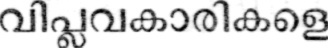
വിപ്ലവകാരികളെ
